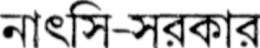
নাৎসি-সরকার
